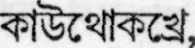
কাউথোকখ্রে,
